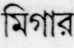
মিগার
